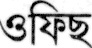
ওফিছ
